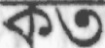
কত
